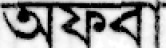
অফবা
